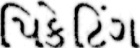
પિકેટિંગ
